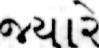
જયારે
